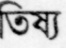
তিষ্য
